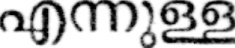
എന്നുള്ള
